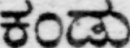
ಕಂಡು
